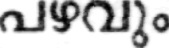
പഴവും
